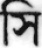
সি
